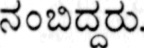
ನಂಬಿದ್ದರು.
